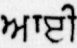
ਆਈ
